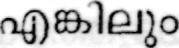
എങ്കിലും
